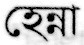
হেন্না
